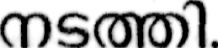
നടത്തി.
